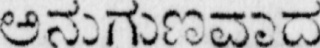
ಅನುಗುಣವಾದ
